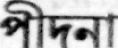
পীদনা
